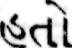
હતો
